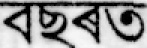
বছৰত
